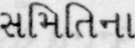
સમિતિના
